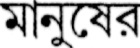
মানুষের
